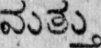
ಮತ್ತು
